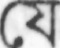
যে
